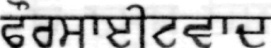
ਫੌਰਸਾਈਟਵਾਦ
